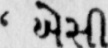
'બેસી
